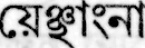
য়েঞ্ছাংনা
